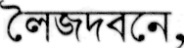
লৈজদবনে,
